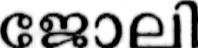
ജോലി
